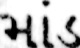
માંડ
